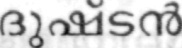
ദുഷ്ടന്‍
